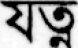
যত্ন
